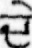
ਦੇ
